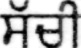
ਸੱਚੀ
